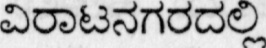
ವಿರಾಟನಗರದಲ್ಲಿ
